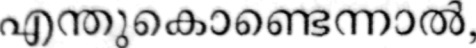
എന്തുകൊണ്ടെന്നാല്‍,
